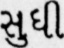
સુધી
